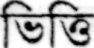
ভিত্তি
